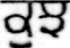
ਕੁਝ
